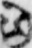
છે
